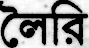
লৈরি
